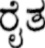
ರೈತ
